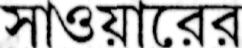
সাওয়ারের
